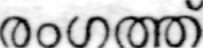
രംഗത്ത്
